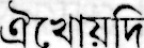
ঐখোয়দি
